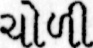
ચોળી
